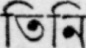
তিনি
